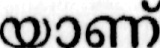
യാണ്
